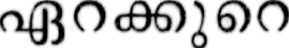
ഏറക്കുറെ
